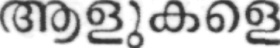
ആളുകളെ
